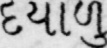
દયાળુ
